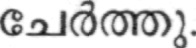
ചേര്‍ത്തു.
